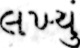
લખ્યું
